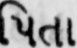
પિતા
